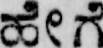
ಹೇಗೆ
